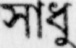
সাধু
